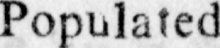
Populated
